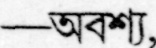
–অবশ্য,
